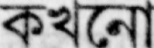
কখনো
